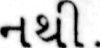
નથી.
